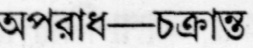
অপরাধ-চক্রান্ত
